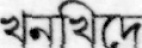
খনখিদে
